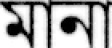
মানা
